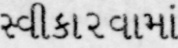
સ્વીકારવામાં
